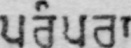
ਪਰੰਪਰਾ
